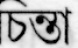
চিন্তা
